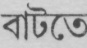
বাটতে
